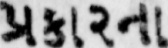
પ્રકારના
